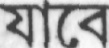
যাবে
